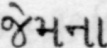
જેમના
